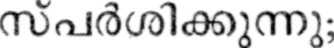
സ്പര്‍ശിക്കുന്നു;
